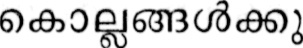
കൊല്ലങ്ങള്‍ക്കു
